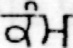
ਕੰਮ
